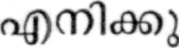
എനിക്കു
